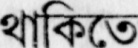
থাকিতে
